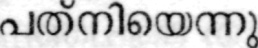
പത്നിയെന്നു
